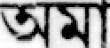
অমা
